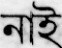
নাই
